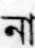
না
